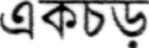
একচড়
